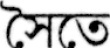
সৈতে
